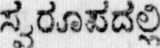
ಸ್ವರೂಪದಲ್ಲಿ
